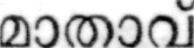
മാതാവ്
